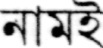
নামই
